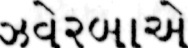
ઝવેરબાએ
